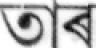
তাৰ
